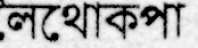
লৈথোকপা
